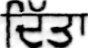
ਦਿੱਤਾ
